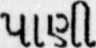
પાણી
